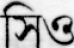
সিও
